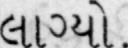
લાગ્યો.
